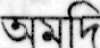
অমদি
